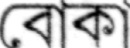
বোকা
